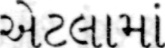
એટલામાં
